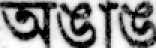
অঙাঙ
